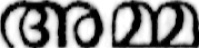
അമ്മ
